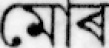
মোৰ
